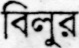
বিলুর
